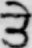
ਤੇ
